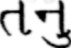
તનુ
